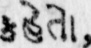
કહેતો,
